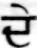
ਦੇ
